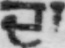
ਦਾ
